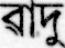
ৱাদু
